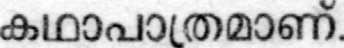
കഥാപാത്രമാണ്.
